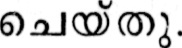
ചെയ്തു.
